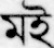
মই
